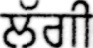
ਲੱਗੀ
